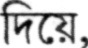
দিয়ে,
